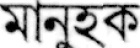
মানুহক
